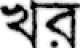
খর
